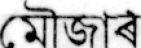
মৌজাৰ
